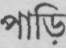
পাড়ি
